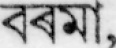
বৰমা,
